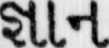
જ્ઞાન
